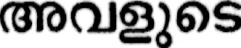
അവളുടെ
